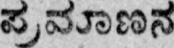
ಪ್ರಮಾಣನ
